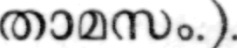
താമസം.)
